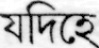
যদিহে
